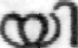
യി
